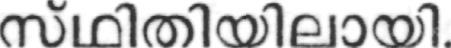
സ്ഥിതിയിലായി.
